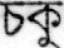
চকু
